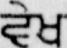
ਵੇਖ
